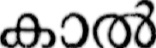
കാല്‍
